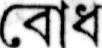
বোধ
